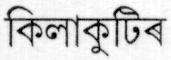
কিলাকুটিৰ
